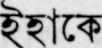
ইহাকে
